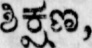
ಶಿಕ್ಷಣ,
